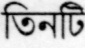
তিনটি
